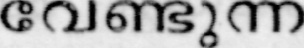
വേണ്ടുന്ന
